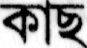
কাছ
